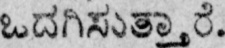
ಒದಗಿಸುತ್ತಾರೆ.
